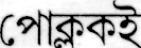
পোক্লকই
